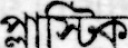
প্লাস্টিক
